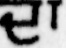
ਦਾ
